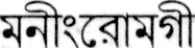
মনীংরোমগী
